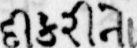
દીકરીનો
